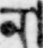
না
